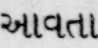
આવતા
